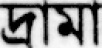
দ্রামা
